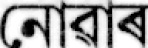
নোৱাৰ
